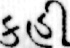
કહી
